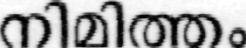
നിമിത്തം
